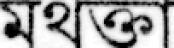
মথক্তা
